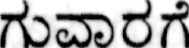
ಗುವಾರಗೆ
